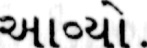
આવ્યો.
